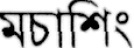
মচাশিং
